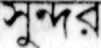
সুন্দর
